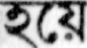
হয়ে
